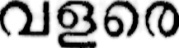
വളരെ
